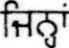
ਜਿਨ੍ਹਾਂ
